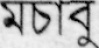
মচাবু
